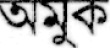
অমুক
